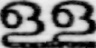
ള്ള
